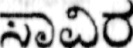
ಸಾವಿರ
